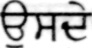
ਉਸਦੇ
